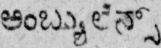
ಆಂಬ್ಯುಲೆನ್ಸ್
